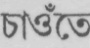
চাওঁতে
